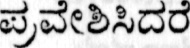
ಪ್ರವೇಶಿಸಿದರೆ
